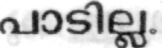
പാടില്ല.
